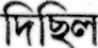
দিছিল
